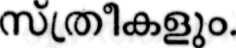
സ്ത്രീകളും.
